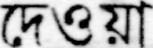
দেওয়া
